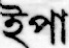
ইপা
